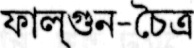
ফাল্গুন-চৈত্র
